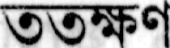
ততক্ষণ
